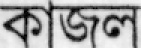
কাজল
